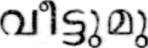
വീട്ടുമു
